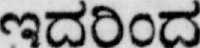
ಇದರಿಂದ
